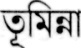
তূমিন্না
